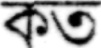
কত
